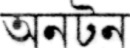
অনটন
